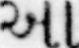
આ
